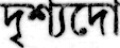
দৃশ্যদো
